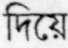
দিয়ে
